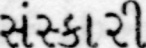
સંસ્કારી
